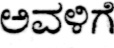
ಅವಳಿಗೆ
